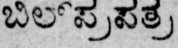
ಬಿಲ್ಪ್ರಪತ್ರ
